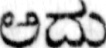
ಅದು
